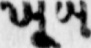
ખૂબ
